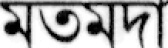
মতমদা
